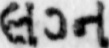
લગ્ન
